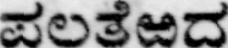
ಪಲತೆಱದ
